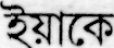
ইয়াকে
